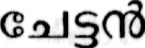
ചേട്ടന്‍
